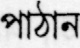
পাঠান
